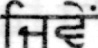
ਜਿਵੇਂ
